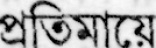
প্রতিমায়ে
